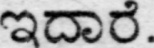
ಇದಾರೆ.
